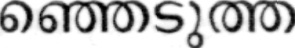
ഞ്ഞെടുത്ത
